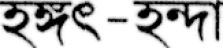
হঙ্গৎ-হন্দা
